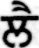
ਲੈ
